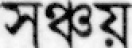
সঞ্চয়
